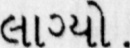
લાગ્યો.
